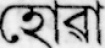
হোৱা
